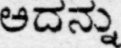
ಅದನ್ನು
